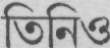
তিনিও
